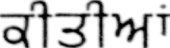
ਕੀਤੀਆਂ
